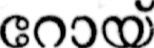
റോയ്
